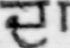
ਦਾ
